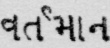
વર્તમાન
